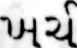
ખર્ચ
